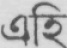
এহি
